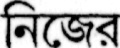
নিজের
